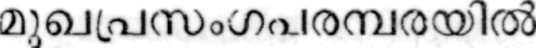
മുഖപ്രസംഗപരമ്പരയില്‍
